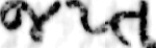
જપ્ત
